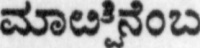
ಮಾೞ್ಪೆನೆಂಬ
